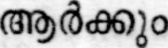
ആര്‍ക്കും
